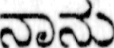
ನಾನು
